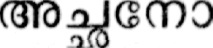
അച്ഛനോ
